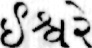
ઇશ્વરે
